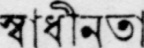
স্বাধীনতা
